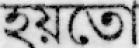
হয়তো
